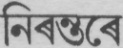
নিৰন্তৰে
